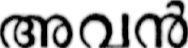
അവന്‍
